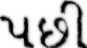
પછી
